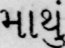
માથું
